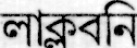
লাক্লবনি
